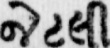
જેટલી
